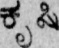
ಕೃಷಿ
